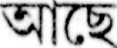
আছে
